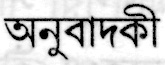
অনুবাদকী
